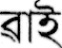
ৱাই
